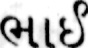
ભાઈ
